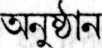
অনুষ্ঠান
